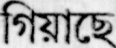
গিয়াছে
